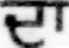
ਦਾ
